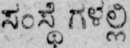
ಸಂಸ್ಥೆಗಳಲ್ಲಿ
